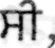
ਸੀ,
